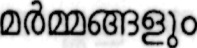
മര്‍മ്മങ്ങളും
